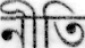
নীতি
